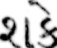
શકે
